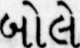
બોલે
